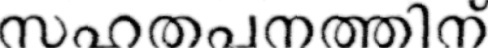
സഹതപനത്തിന്
